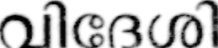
വിദേശി
